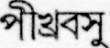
পীখ্রবসু
